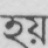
হয়
